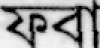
ফবা
